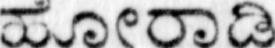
ಹೋರಾಡಿ
